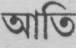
আতি
